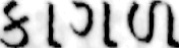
કાગળ
